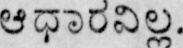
ಆಧಾರವಿಲ್ಲ.
